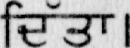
ਦਿੱਤਾ।
